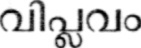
വിപ്ലവം
